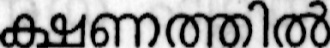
ക്ഷണത്തില്‍
